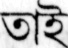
তাই
